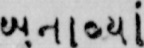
બનાવ્યાં
